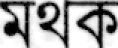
মথক
